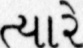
ત્યારે
